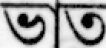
ভাত
